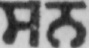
ਸਨ
